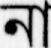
না
